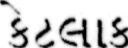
કેટલાક
